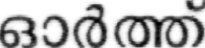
ഓര്‍ത്ത്
